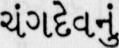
ચંગદેવનું
